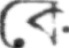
কে
